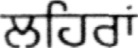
ਲਹਿਰਾਂ
